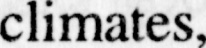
climates,
